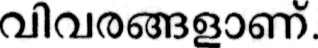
വിവരങ്ങളാണ്.
